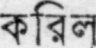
করিল
